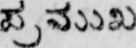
ಪ್ರಮುಖ
